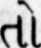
તો
